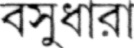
বসুধারা
